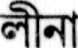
লীনা
